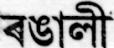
ৰঙালী
